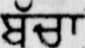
ਬੱਚਾ
